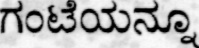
ಗಂಟೆಯನ್ನೂ
